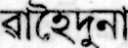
ৱাহৈদুনা
